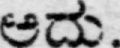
ಅದು.
